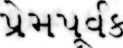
પ્રેમપૂર્વક
